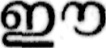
ഈ
